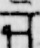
ਜੋ
